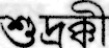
শুদ্রক্কী
